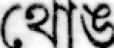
থোঙ
